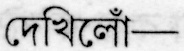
দেখিলোঁ-
